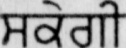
ਸਕੇਗੀ
